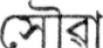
সৌৱা
